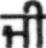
ਜੀ
